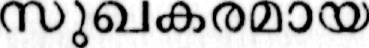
സുഖകരമായ
